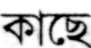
কাছে
